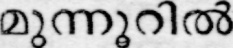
മുന്നൂറില്‍
